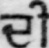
ਦੀ
